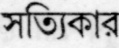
সত্যিকার
